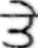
ਤੇ
